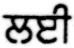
ਲਈ
